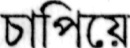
চাপিয়ে
